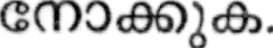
നോക്കുക.
